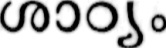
ശാഠ്യം
